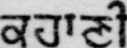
ਕਹਾਣੀ
